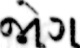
જોગ
